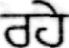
ਰਹੇ
